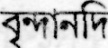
বৃন্দানদি
